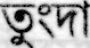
তুংদা
